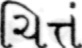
ચિત્તં
